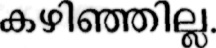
കഴിഞ്ഞില്ല.
